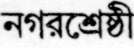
নগরশ্রেষ্ঠী
